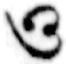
ও
